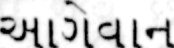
આગેવાન
